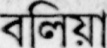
বলিয়া
